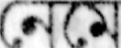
নেমে
